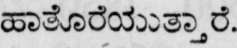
ಹಾತೊರೆಯುತ್ತಾರೆ.
